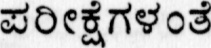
ಪರೀಕ್ಷೆಗಳಂತೆ
